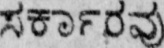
ಸರ್ಕಾರವು
